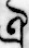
ঐ
